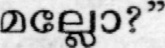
മല്ലോ?"
